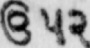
ઉપર
